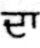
ਦਾ
